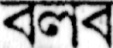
বলব
